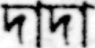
দাদা
